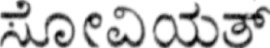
ಸೋವಿಯತ್
